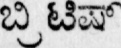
ಬ್ರಿಟಿಷ್
